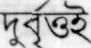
দুর্বত্তই
